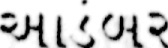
આડંબર
